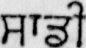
ਸਾਡੀ
